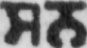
ਸਨ
